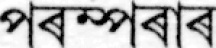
পৰম্পৰাৰ
